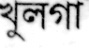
খুলগা
